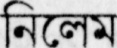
নিলেম
